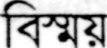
বিস্ময়
